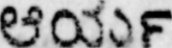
ಆರ್ಯ
